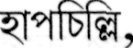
হাপচিল্লি,
